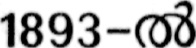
1893-ല്‍
